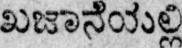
ಖಜಾನೆಯಲ್ಲಿ
